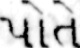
પોતે
